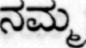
ನಮ್ಮ
